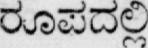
ರೂಪದಲ್ಲಿ
